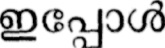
ഇപ്പോള്‍
